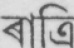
ৰাত্রি
